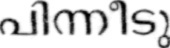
പിന്നീടു
